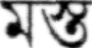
মস্ত
